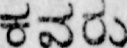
ಕವರು
